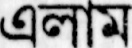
এলাম
